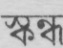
স্কন্ধ
